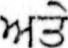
ਅਤੇ
